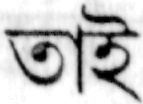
তাই
